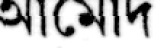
আমোদ
